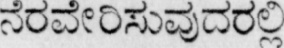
ನೆರವೇರಿಸುವುದರಲ್ಲಿ
